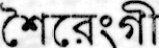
শৈরেংগী
